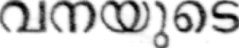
വനയുടെ
